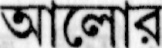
আলোর
